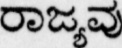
ರಾಜ್ಯವು
